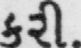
કરી.
